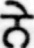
ਨੇ
